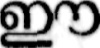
ഈ
